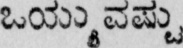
ಒಯ್ಯುವಷ್ಟು
